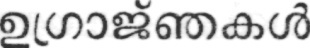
ഉഗ്രാജ്ഞകള്‍
